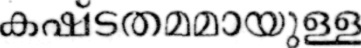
കഷ്ടതമമായുള്ള
